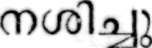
നശിച്ചു
